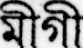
মীগী
